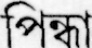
পিন্ধা
